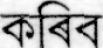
কৰিব
